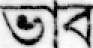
ভাব
